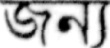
জন্য
